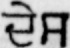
ਦੇਸ
